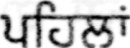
ਪਹਿਲਾਂ
